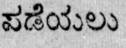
ಪಡೆಯಲು
